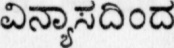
ವಿನ್ಯಾಸದಿಂದ
